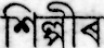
শিল্পীৰ
